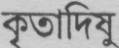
কৃতাদিষু
